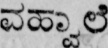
ವಹ್ವಾಲೆ
